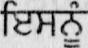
ਇਸਨੂੰ
